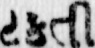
ટકતી
